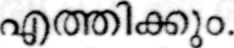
എത്തിക്കും.
